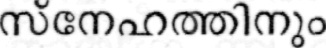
സ്നേഹത്തിനും
